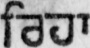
ਰਿਹਾ
